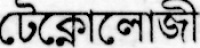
টেক্নোলোজী
